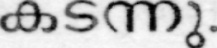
കടന്നു.
